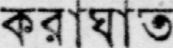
করাঘাত
